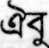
ঐবু
